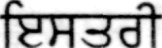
ਇਸਤਰੀ
